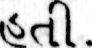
હતી.
